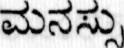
ಮನಸ್ಸು
